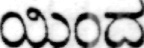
ಯಿಂದ
